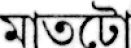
মাতটো
